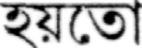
হয়তো
